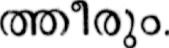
ത്തീരും.
